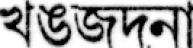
খঙজদনা
